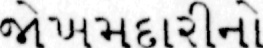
જોખમદારીનો
